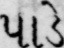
પાડે
